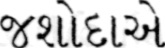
જશોદાએ
